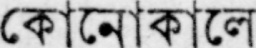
কোনোকালে
